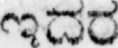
ಇದರ
